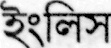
ইংলিস
